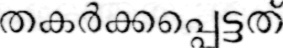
തകര്‍ക്കപ്പെട്ടത്
